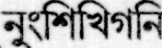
নুংশিখিগনি
